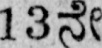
13ನೇ
